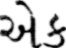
એક
